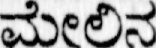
ಮೇಲಿನ
